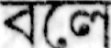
বলে
